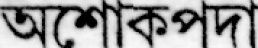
অশোকপদা
